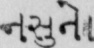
નસુનો
